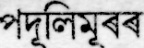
পদূলিমূৰৰ
